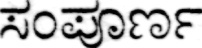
ಸಂಪೂರ್ಣ
